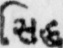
સિદ્ધ
